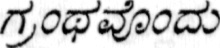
ಗ್ರಂಥವೊಂದು
